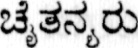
ಚೈತನ್ಯರು
